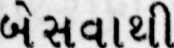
બેસવાથી
